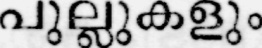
പുല്ലുകളും
